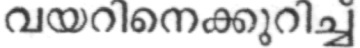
വയറിനെക്കുറിച്ച്
